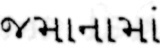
જમાનામાં
